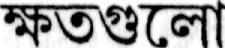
ক্ষতগুলো
